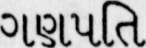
ગણપતિ
